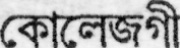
কোলেজগী
